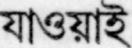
যাওয়াই
